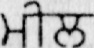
ਮੀਲ
